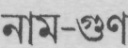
নাম-গুণ
